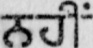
ਨਹੀਂ
